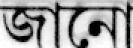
জানো
